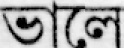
ভালে
